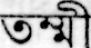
তম্মী
